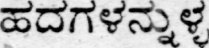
ಹದಗಳನ್ನುಳ್ಳ
